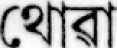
থোৱা
